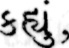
કહ્યું,
